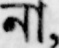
না,
